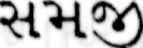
સમજી
